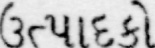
ઉત્પાદકો
